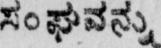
ಸಂಘವನ್ನು
